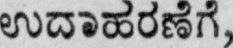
ಉದಾಹರಣೆಗೆ,
